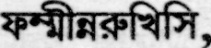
ফম্মীন্নরুখিসি,
